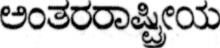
ಅಂತರರಾಷ್ಟ್ರೀಯ
